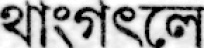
থাংগৎলে
